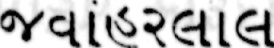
જવાંહરલાલ
